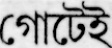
গোটেই
